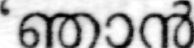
‘ഞാന്‍
